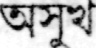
অসুখ
